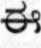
ಈ
